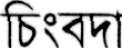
চিংবদা
